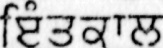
ਇੰਤਕਾਲ
